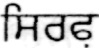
ਸਿਰਫ਼
